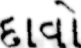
દાવો
